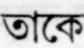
তাকে
